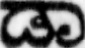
ಡಾ
